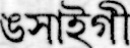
ঙসাইগী
